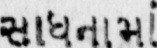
સાધનામાં
